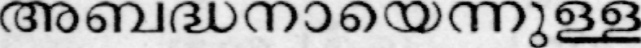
അബദ്ധനായെന്നുള്ള
